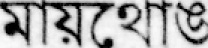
মায়থোঙ
